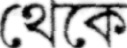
থেকে
